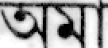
অমা
